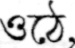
ওঠে,
